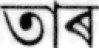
তাৰ
